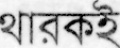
থারকই
